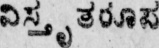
ವಿಸ್ತೃತರೂಪ
